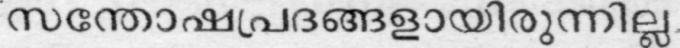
സന്തോഷപ്രദങ്ങളായിരുന്നില്ല.
